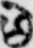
છે
